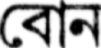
বোন
